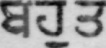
ਬਹੁਤ
